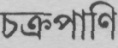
চক্রপাণি
